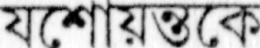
যশোয়ন্তকে
